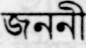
জননী
